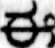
ಈ
